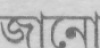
জানো
